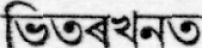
ভিতৰখনত
